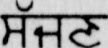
ਸੱਜਣ
